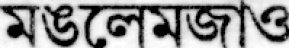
মঙলেমজাও
